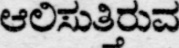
ಆಲಿಸುತ್ತಿರುವ
